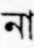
না
